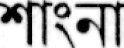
শাংনা
